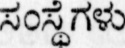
ಸಂಸ್ಥೆಗಳು
